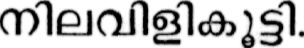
നിലവിളികൂട്ടി.
